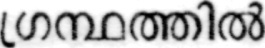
ഗ്രന്ഥത്തില്‍
